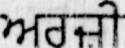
ਅਰਜ਼ੀ
